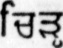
ਚਿੜ੍ਹ
